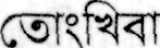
তোংখিবা
